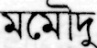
মমৌদু
